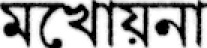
মখোয়না
